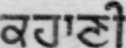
ਕਹਾਣੀ
